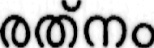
രത്നം
